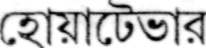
হোয়াটেভার
